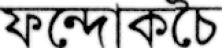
ফন্দোকচৈ
